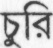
চুরি
